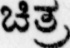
ಚಿತ್ರ
